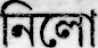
নিলো
